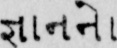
જ્ઞાનનો
